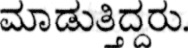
ಮಾಡುತ್ತಿದ್ದರು.
